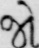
જો
